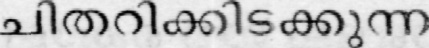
ചിതറിക്കിടക്കുന്ന
